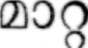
മാറ്റ
